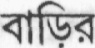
বাড়ির
